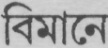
বিমানে
